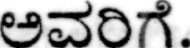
ಅವರಿಗೆ.
